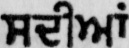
ਸਦੀਆਂ
